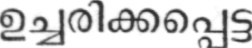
ഉച്ചരിക്കപ്പെട്ട
